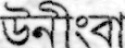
উনীংবা
